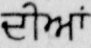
ਦੀਆਂ
